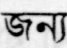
জন্য
